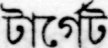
টার্গেট
